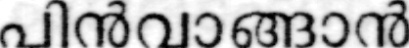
പിന്‍വാങ്ങാന്‍
